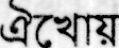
ঐখোয়
